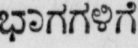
ಭಾಗಗಳಿಗೆ
